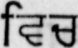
ਵਿਚ
